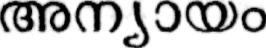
അന്യായം
